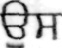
ਉਸ
